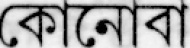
কোনোবা
